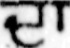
ਦਾ
